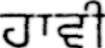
ਹਾਵੀ
